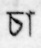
চা
